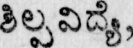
ಶಿಲ್ಪವಿದ್ಯೆ,
